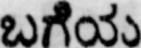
ಬಗೆಯ
